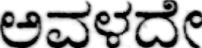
ಅವಳದೇ
